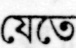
যেতে
